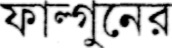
ফাল্গুনের
